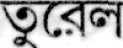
তুরেল
